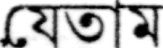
যেতাম
